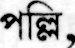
পল্লি,
